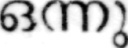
ഒന്നു
